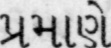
પ્રમાણે
